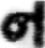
ન
